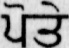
ਪੋਤੇ
